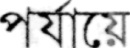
পর্যায়ে
